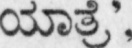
ಯಾತ್ರೆ’,
